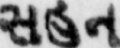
સહન
